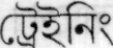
ট্রেইনিং
